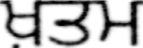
ਖ਼ਤਮ
